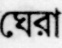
ঘেরা
